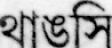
থাঙসি
